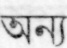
অন্য
